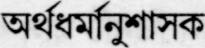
অর্থধর্মানুশাসক
